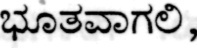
ಭೂತವಾಗಲಿ,
